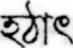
হঠাৎ
